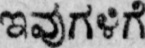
ಇವುಗಳಿಗೆ
